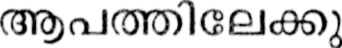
ആപത്തിലേക്കു
